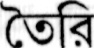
তৈরি
